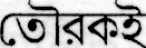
তৌরকই
